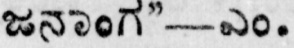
ಜನಾಂಗ”-ಎಂ.
